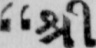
“શ્રી
